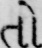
તો
